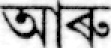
আৰু
